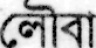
লৌবা
